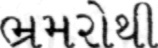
ભ્રમરોથી
